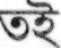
তই
